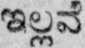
ಇಲ್ಲವೆ
